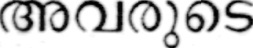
അവരുടെ
